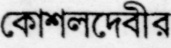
কোশলদেবীর
